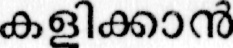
കളിക്കാന്‍
